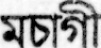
মচাগী
